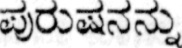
ಪುರುಷನನ್ನು
